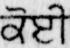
ਕੋਈ
